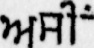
ਅਸੀਂ
